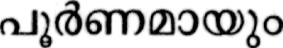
പൂര്‍ണമായും
